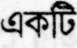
একটি
